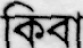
কিবা
